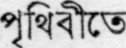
পৃথিবীতে
